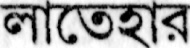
লাতেহার
